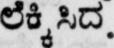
ಲೆಕ್ಕಿಸಿದ.
